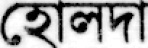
হোলদা
